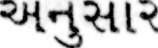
અનુસાર
